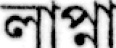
লাপ্না
